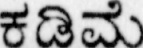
ಕಡಿಮೆ
